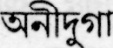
অনীদুগা
